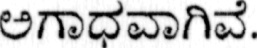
ಅಗಾಧವಾಗಿವೆ.
